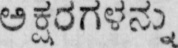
ಅಕ್ಷರಗಳನ್ನು
